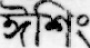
ঈশিং
